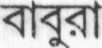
বাবুরা
